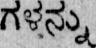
ಗಳನ್ನು
